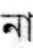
না
